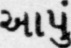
આપું
